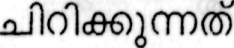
ചിറിക്കുന്നത്
